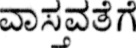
ವಾಸ್ತವತೆಗೆ
